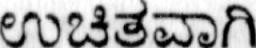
ಉಚಿತವಾಗಿ
